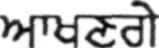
ਆਖਣਗੇ
